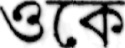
ওকে
